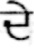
ਦੇ
